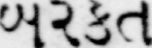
બરકત
